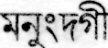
মনুংদগী
